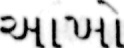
આખો
